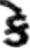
કે
